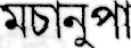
মচানুপা
